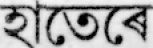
হাতেৰে
